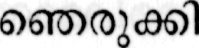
ഞെരുക്കി
